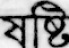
ষষ্টি
